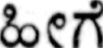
ಹೀಗೆ
